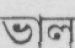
ভাল
